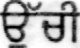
ਉੱਚੀ
